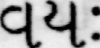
વયઃ
